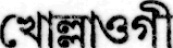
খোল্লাওগী
